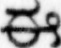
ಈ
